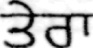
ਤੇਰਾ
